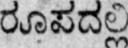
ರೂಪದಲ್ಲಿ
